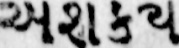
અશક્ય
